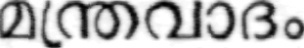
മന്ത്രവാദം
